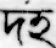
দহ
